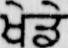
ਖੇਡੇ
